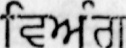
ਵਿਅੰਗ
